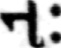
નઃ
